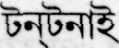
টন্‌টনাই
